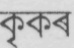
কৃকৰ
